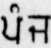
ਪੰਜ
